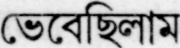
ভেবেছিলাম
